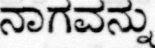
ನಾಗವನ್ನು
